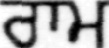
ਰਾਮ
